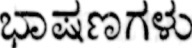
ಭಾಷಣಗಳು
